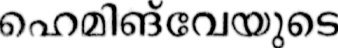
ഹെമിങ്വേയുടെ
